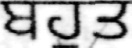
ਬਹੁਤ
